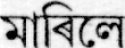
মাৰিলে
